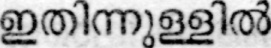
ഇതിന്നുള്ളില്‍
